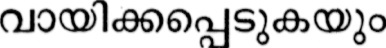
വായിക്കപ്പെടുകയും
